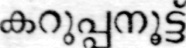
കറുപ്പനൂട്ട്
